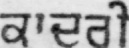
ਕਾਦਰੀ
